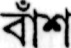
বাঁশ
